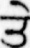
ਤੇ
